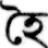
হৈ
